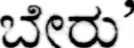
ಬೇರು'
